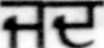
ਜਦ
